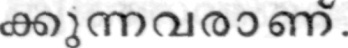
ക്കുന്നവരാണ്.
